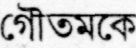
গৌতমকে
